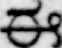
ಈ
